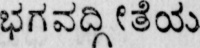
ಭಗವದ್ಗೀತೆಯ
